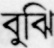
বুঝি
